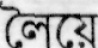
লৈয়ে
